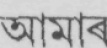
আমাৰ
